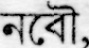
নবৌ,
